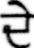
ਦੇ
